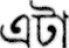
এটা
